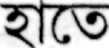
হাতে
